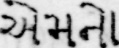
એમનો
